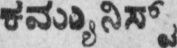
ಕಮ್ಯುನಿಸ್ಟ್
